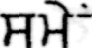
ਸਮੇਂ
